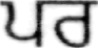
ਪਰ
